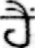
ਹੈਂ
